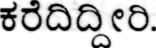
ಕರೆದಿದ್ದೀರಿ.
